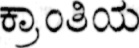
ಕ್ರಾಂತಿಯ
